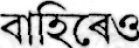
বাহিৰেও
